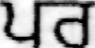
ਪਰ
